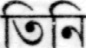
তিনি
